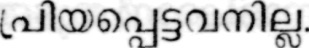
പ്രിയപ്പെട്ടവനില്ല.
